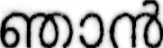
ഞാന്‍
